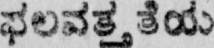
ಫಲವತ್ತತೆಯ
